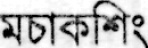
মচাকশিং
